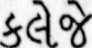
કલેજે
